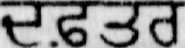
ਦਫ਼ਤਰ
